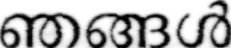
ഞങ്ങള്‍
